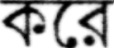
করে
